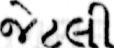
જેટલી
